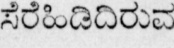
ಸೆರೆಹಿಡಿದಿರುವ
